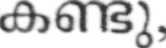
കണ്ടു,
